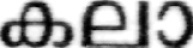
കലാ
